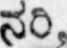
ನರಿ,
